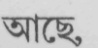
আছে,
